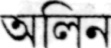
অলিন
